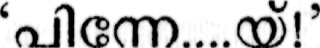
'പിന്നേ....യ്!'
